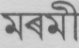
মৰমী
